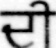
ਦੀ
